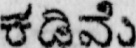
ಕಡಿಮೆ
